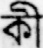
কী
